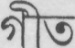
গীত
